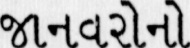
જાનવરોનો
